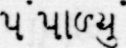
પંપાળ્યું
